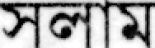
সলাম
